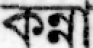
কন্না
